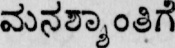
ಮನಶ್ಯಾಂತಿಗೆ
